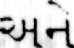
અને
